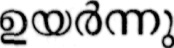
ഉയര്‍ന്നു
